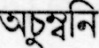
অচুম্বনি
